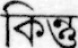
কিন্তু
